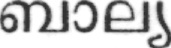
ബാല്യ
